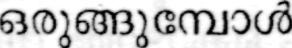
ഒരുങ്ങുമ്പോള്‍
